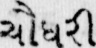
ચૌધરી
